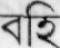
বহি
